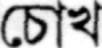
চোখ
